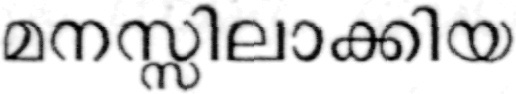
മനസ്സിലാക്കിയ
